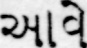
આવે
